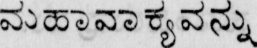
ಮಹಾವಾಕ್ಯವನ್ನು
